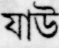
যাউ
